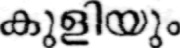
കുളിയും
